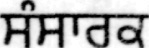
ਸੰਸਾਰਕ
